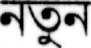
নতুন
